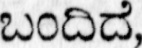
ಬಂದಿದೆ,
